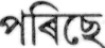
পৰিছে
